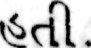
હતી.
